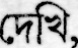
দেখি,
